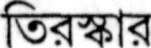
তিরস্কার
